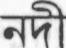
নদী
